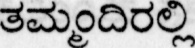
ತಮ್ಮಂದಿರಲ್ಲಿ
